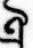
ঐ
